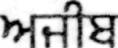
ਅਜੀਬ
